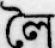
লৈ
